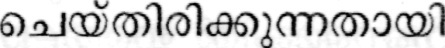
ചെയ്തിരിക്കുന്നതായി
